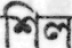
শিল
